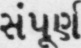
સંપૂર્ણ
